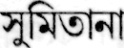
সুমিতানা
